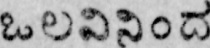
ಒಲವಿನಿಂದ
